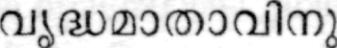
വൃദ്ധമാതാവിനു
